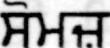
ਸੋਮਜ਼
